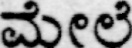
ಮೇಲೆ
